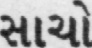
સાચો
